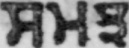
ਸਮਝ
